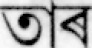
তাৰ
